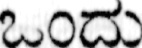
ಒಂದು
